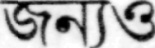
জন্যও
